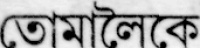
তোমালৈকে
